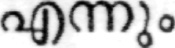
എന്നും
